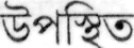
উপস্থিত
